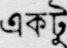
একটু
